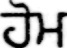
ਹੋਮ
